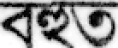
বহুত
